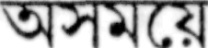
অসময়ে
